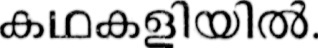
കഥകളിയില്‍.
